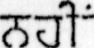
ਨਹੀਂ
